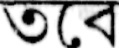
তবে
